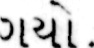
ગયો.
